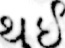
થઈ
